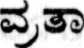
ವ್ರತಾ
